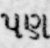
પણ
